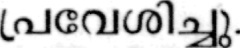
പ്രവേശിച്ചു.
